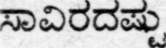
ಸಾವಿರದಷ್ಟು
